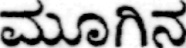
ಮೂಗಿನ
